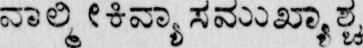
ವಾಲ್ಮೀಕಿವ್ಯಾಸಮುಖ್ಯಾಶ್ಚ
